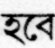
হবে
